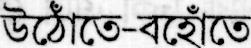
উঠোঁতে-বহোঁতে
